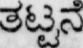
ತಟ್ಟನೆ
